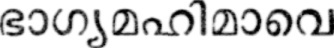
ഭാഗ്യമഹിമാവെ
